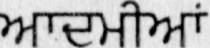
ਆਦਮੀਆਂ
